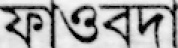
ফাওবদা
